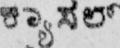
ಕ್ಯಾಸಲ್
